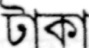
টাকা
